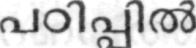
പഠിപ്പില്‍
